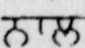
ਨਾਲ
